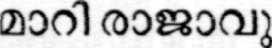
മാറിരാജാവു
